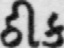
ઠીક
